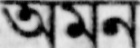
অমন
